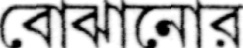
বোঝানোর
